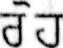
ਰੋਹ
